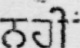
ਨਹੀਂ
